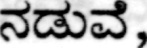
ನಡುವೆ,
